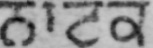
ਨਾਟਕ
